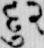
દુર
